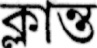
ক্লান্ত
